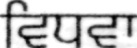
ਵਿਧਵਾ
